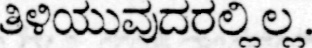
ತಿಳಿಯುವುದರಲ್ಲಿಲ್ಲ.
